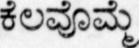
ಕೆಲವೊಮ್ಮೆ
